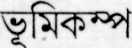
ভূমিকম্প
